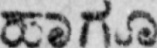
ಹಾಗೂ
